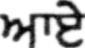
ਆਏ
